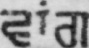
ਵਾਂਗ
